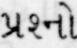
પ્રશ્નો
